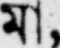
মা,
